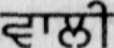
ਵਾਲੀ
